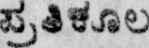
ಪ್ರತಿಕೂಲ
